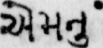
એમનું
